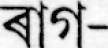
ৰাগ-
